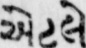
એટલે
